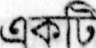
একটি
